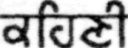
ਕਹਿਣੀ
